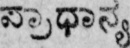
ಪ್ರಾಧಾನ್ಯ
